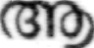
ആ
